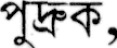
পুদ্রুক,
